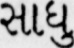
સાધુ
